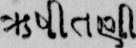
ઋષીતણી
